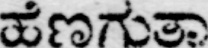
ಹೆಣಗುತಾ
